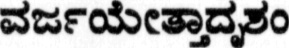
ವರ್ಜಯೇತ್ತಾದೃಶಂ
